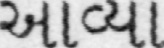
આવ્યા
